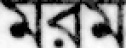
মরম
